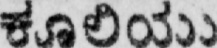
ಕೂಲಿಯು
